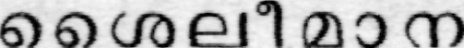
ശൈലീമാന
